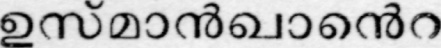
ഉസ്മാന്‍ഖാന്റെ
